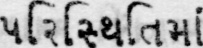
પરિસ્થિતિમાં
